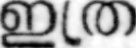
ഇത്ര
